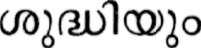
ശുദ്ധിയും
